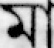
মা
